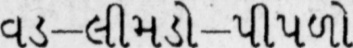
વડ-લીમડો-પીપળો
